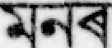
মনৰ
